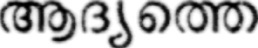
ആദ്യത്തെ
